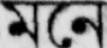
মনে
